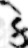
કે
